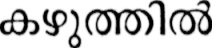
കഴുത്തില്‍
